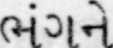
ભંગને
